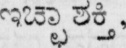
ಇಚ್ಛಾಶಕ್ತಿ,
